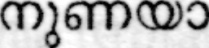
നുണയാ
